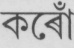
কৰোঁ
